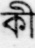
কী
